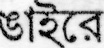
ঙাইরে
